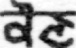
ਕੌਣ
